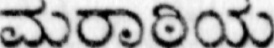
ಮರಾಠಿಯ
